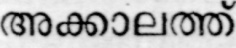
അക്കാലത്ത്
